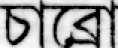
চাব্রো
